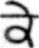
ਕੇ
